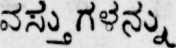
ವಸ್ತುಗಳನ್ನು
